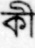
কী
